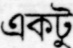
একটু
